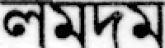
লমদম
